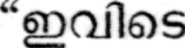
“ഇവിടെ
